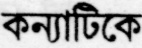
কন্যাটিকে
